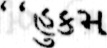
"હુકમ
